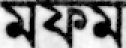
অসিদা
